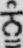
ਨੂੰ
